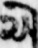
એ
